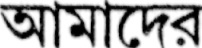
আমাদের
